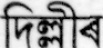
দিল্লীৰ
